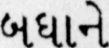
બધાને
